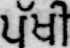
ਪੱਖੀ
